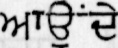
ਆਉਂਦੇ
